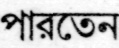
পারতেন
